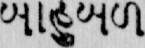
બાહુબળ
